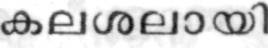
കലശലായി
